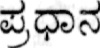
ಪ್ರಧಾನ
